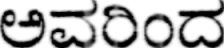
ಅವರಿಂದ
